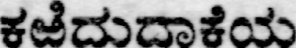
ಕಱೆದುದಾಕೆಯ
